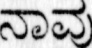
ನಾವು
